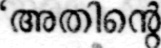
'അതിന്റെ
